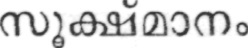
സൂക്ഷ്മാനം
